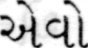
એવો
